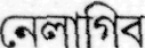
নেলাগিব
